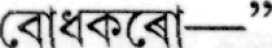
বোধকৰো-"
